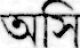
অসি
